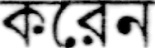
করেন
